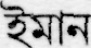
ইমান
